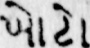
ખોટો
